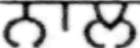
ਨਾਲ
